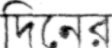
দিনের
